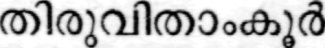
തിരുവിതാംകൂര്‍
